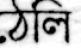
ঠেলি
